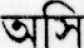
অসি
